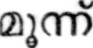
മൂന്ന്
